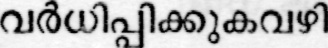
വര്‍ധിപ്പിക്കുകവഴി
